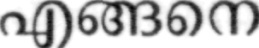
എങ്ങനെ
